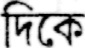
দিকে
